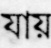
যায়
